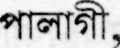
পালাগী,
